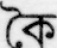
কৈ
